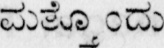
ಮತ್ತೊಂದು
